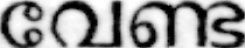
വേണ്ട
